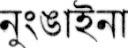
নুংঙাইনা
